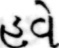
હવે
